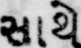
સાથે
